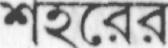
শহরের
